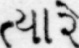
ત્યારે
